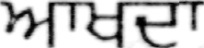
ਆਖਦਾ
